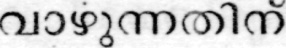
വാഴുന്നതിന്
